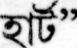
হার্ট”
